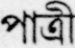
পাত্রী
